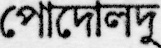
পোদোলদু
